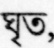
ঘৃত,
